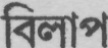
বিলাপ
